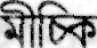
মীচিক
